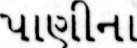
પાણીના
